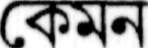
কেমন
